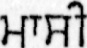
ਮਾਸੀ
